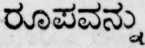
ರೂಪವನ್ನು
